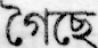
গৈছে
